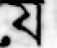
যে
